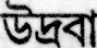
উদ্রবা
